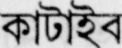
কাটাইব
